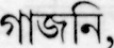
গাজনি,
